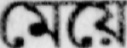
মেয়ে
